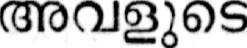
അവളുടെ
